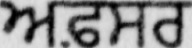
ਅਫ਼ਸਰ
